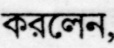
করলেন,
